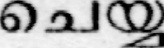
ചെയ്യ
